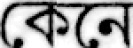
কেনে
